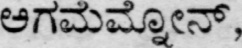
ಅಗಮೆಮ್ನೋನ್,
